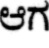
ಆಗ
